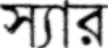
স্যার
